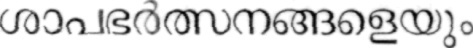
ശാപഭര്‍ത്സനങ്ങളെയും
